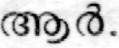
ആര്‍.
